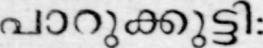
പാറുക്കുട്ടി:
